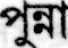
পুন্না
